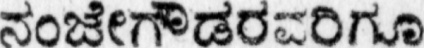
ನಂಜೇಗೌಡರವರಿಗೂ
